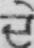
ਦੇ
